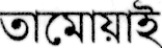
তামোয়াই
